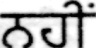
ਨਹੀਂ
